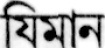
যিমান
